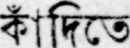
কাঁদিতে
